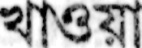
খাওয়া
